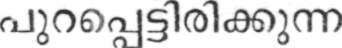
പുറപ്പെട്ടിരിക്കുന്ന
